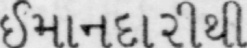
ઈમાનદારીથી
